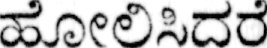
ಹೋಲಿಸಿದರೆ
